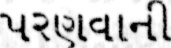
પરણવાની
